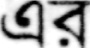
এর
